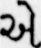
એ
